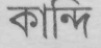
কান্দি
